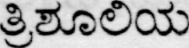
ತ್ರಿಶೂಲಿಯ
